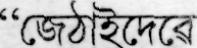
"জেঠাইদেৱে
